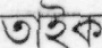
তাইক
